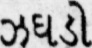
ઝઘડો
